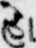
હો
